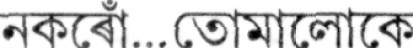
নকৰোঁ...তোমালোকে
